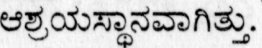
ಆಶ್ರಯಸ್ಥಾನವಾಗಿತ್ತು.
